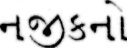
નજીકનો
